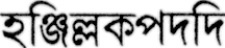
হঞ্জিল্লকপদদি
